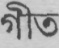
গীত
